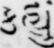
કહ્યું
